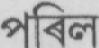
পৰিল
